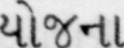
યોજના
